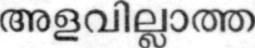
അളവില്ലാത്ത
